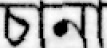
চানা
